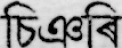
চিঞৰি
